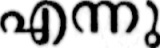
എന്നു
